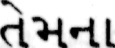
તેમના
